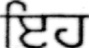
ਇਹ
